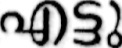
എട്ടു
